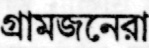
গ্রামজনেরা
